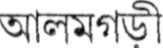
আলমগড়ী
